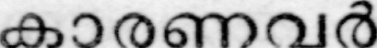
കാരണവര്‍
